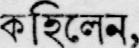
কহিলেন,
